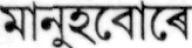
মানুহবোৰে
